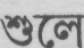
শুলে
